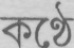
কণ্ঠে
